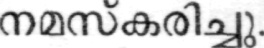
നമസ്കരിച്ചു.
